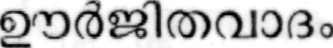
ഊര്‍ജിതവാദം
